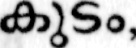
കുടം,
